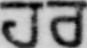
ਹਰ
